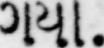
ગયા.
